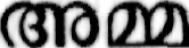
അമ്മ
